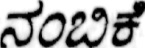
ನಂಬಿಕೆ
